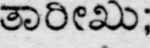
ತಾರೀಖು;
